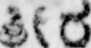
ತೀರ
